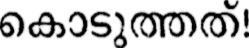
കൊടുത്തത്!
